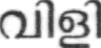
വിളി
